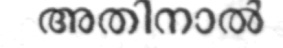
അതിനാല്‍
